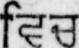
ਵਿਚ
